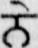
ਨੇ
